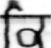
ਕਿ
